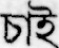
চাই
